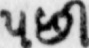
પછી
